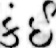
કંઈ
